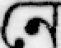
নে
